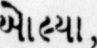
બોલ્યા,
